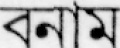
বনাম
